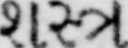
શસ્ત્ર
